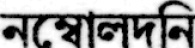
নম্বোলদনি
